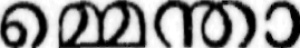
മ്മെന്താ
